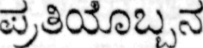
ಪ್ರತಿಯೊಬ್ಬನ
